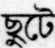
ছুটে
